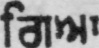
ਗਿਆ
